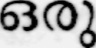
ഒരു
